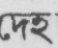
দেহ
